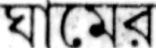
ঘামের
